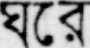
ঘরে
